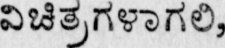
ವಿಚಿತ್ರಗಳಾಗಲಿ,
